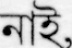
নাই,
